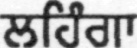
ਲਹਿੰਗਾ
